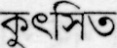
কুৎসিত
